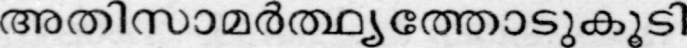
അതിസാമര്‍ത്ഥ്യത്തോടുകൂടി
